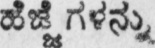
ಹೆಜ್ಜೆಗಳನ್ನು
